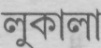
লুকালা
